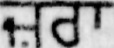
ਜ਼ਰਾ
